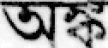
অঙ্ক
